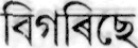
বিগৰিছে
